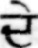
ਦੇ
